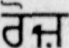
ਰੋਜ਼
